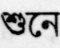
শুনে
